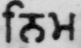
ਨਿਮ
